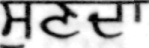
ਸੁਣਦਾ
